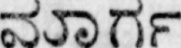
ಮಾರ್ಗ
